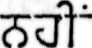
ਨਹੀਂ
